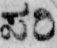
ಸರಿ
